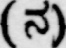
(ನ)
